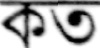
কত
